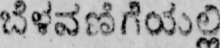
ಬೆಳವಣಿಗೆಯಲ್ಲಿ
